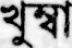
খুম্বা
